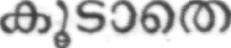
കൂടാതെ
